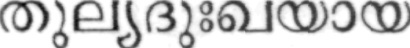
തുല്യദുഃഖയായ
